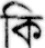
কি
